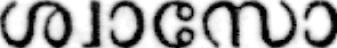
ശ്വാസോ
